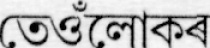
তেওঁলোকৰ
